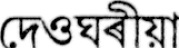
দেওঘৰীয়া
